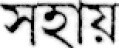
সহায়
